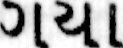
ગયા
